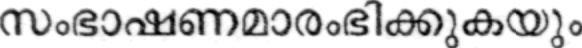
സംഭാഷണമാരംഭിക്കുകയും
